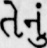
તેનું
